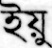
ইয়ু
